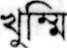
খুম্মি
